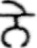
ਨੇ
